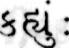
કહ્યુંઃ
